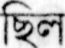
ছিল
